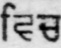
ਵਿਚ
